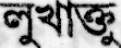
লুখাক্তু
